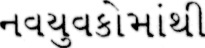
નવયુવકોમાંથી
